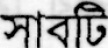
সাবটি
